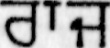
ਰਾਜ
